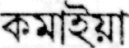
কমাইয়া
